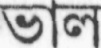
ভাল
